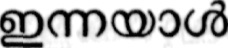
ഇന്നയാള്‍
